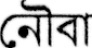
নৌবা
